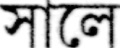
সালে
